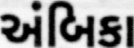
અંબિકા
